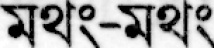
মথং-মথং
